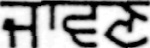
ਜਾਵਣ
